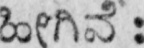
ಹೀಗಿವೆ:
